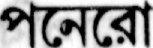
পনেরো
